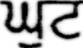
ਘੁਟ
